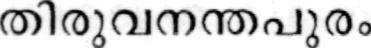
തിരുവനന്തപുരം
